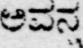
ಅವನ್ನ
